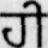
ਹੀ
